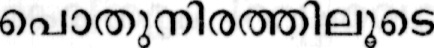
പൊതുനിരത്തിലൂടെ
